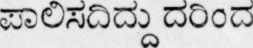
ಪಾಲಿಸದಿದ್ದುದರಿಂದ
